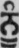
ਨੂੰ
